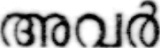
അവര്‍
